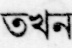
তখন
